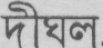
দীঘল,
